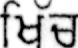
ਖਿੱਚ
